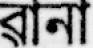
ৱানা
